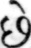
છે
